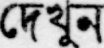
দেখুন
